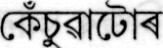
কেঁচুৱাটোৰ
